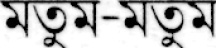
মতুম-মতুম
